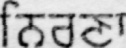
ਨਿਰਣਾ
